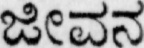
ಜೀವನ
